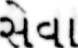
સેવા
